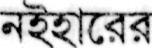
নইহারের
